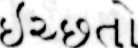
ઈચ્છતો
